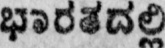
ಭಾರತದಲ್ಲಿ
